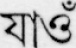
যাওঁ
